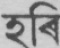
হৰি
